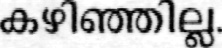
കഴിഞ്ഞില്ല.
